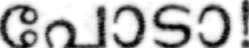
പോടാ!
